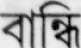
বান্ধি
